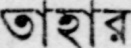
তাহার
